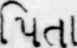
પિતા
